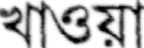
খাওয়া
